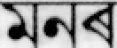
মনৰ
